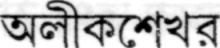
অলীকশেখর
